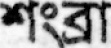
শংব্রা
